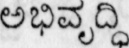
ಅಭಿವೃದ್ಧಿ
